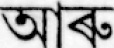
আৰু
